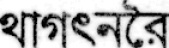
থাগৎনরৈ
